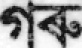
গৰু
